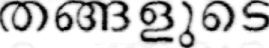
തങ്ങളുടെ
